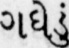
ગધેડું
